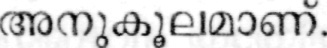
അനുകൂലമാണ്.
